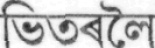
ভিতৰলৈ
